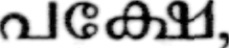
പക്ഷേ,
